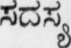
ಸದಸ್ಯ
